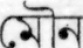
মৌন
